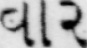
વાર
